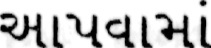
આપવામાં
